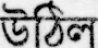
উঠিল
